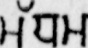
ਮੱਧਮ
